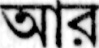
আর
